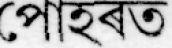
পোহৰত
